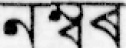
নম্বৰ
